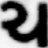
ચ
